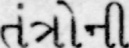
તંત્રોની
